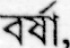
বর্ষা,
